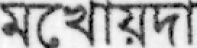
মখোয়না
